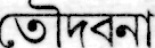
তৌদবনা
